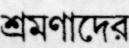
শ্রমণাদের
